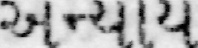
અન્યાય
